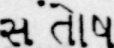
સંતોષ
